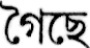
গৈছে
